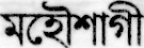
মহৌশাগী
